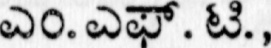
ಎಂ.ಎಫ್.ಟಿ.,
